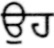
ਉਹ
